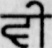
ਵੀ
